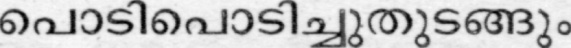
പൊടിപൊടിച്ചുതുടങ്ങും
